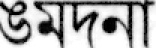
ঙমদনা
